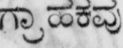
ಗ್ರಾಹಕವು
